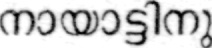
നായാട്ടിനു
